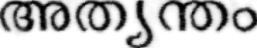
അത്യന്തം
